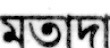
মতাদা
